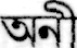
অনী
